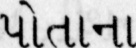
પોતાના
